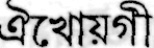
ঐখোয়গী
